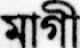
মাগী
